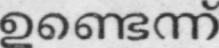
ഉണ്ടെന്ന്
